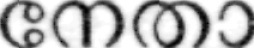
നേതാ
